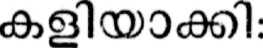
കളിയാക്കി:
